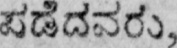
ಪಡೆದವರು,
